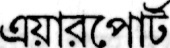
এয়ারপোর্ট
